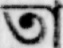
তা
